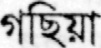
গছিয়া
